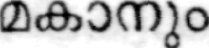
മകാനും
